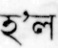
হ'ল
